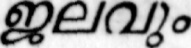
ജലവും
